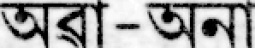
অৱা-অনা
